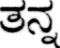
ತನ್ನ
